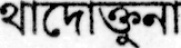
থাদোক্তুনা
